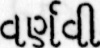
વર્ણવી
